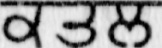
ਕਤਲ
